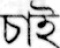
চাই
